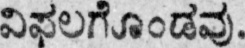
ವಿಫಲಗೊಂಡವು.
